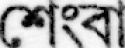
শেংবা
